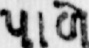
પાળે
